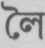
লৈ
